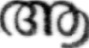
ആ
